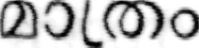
മാത്രം
